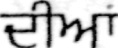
ਦੀਆਂ
